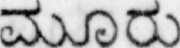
ಮೂರು
